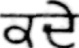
ਕਦੇ
